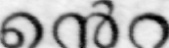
ന്റെ
